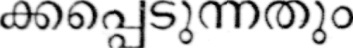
ക്കപ്പെടുന്നതും
